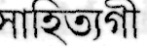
সাহিত্যগী
